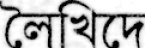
লৈখিদে
